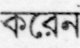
করেন
